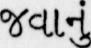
જવાનું
